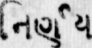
નિર્ણય
